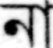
না
